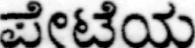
ಪೇಟೆಯ
